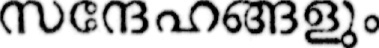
സന്ദേഹങ്ങളും
